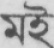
মই
